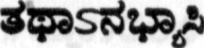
ತಥಾsನಭ್ಯಾಸಿ
